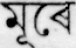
মূৰে
